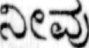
ನೀವು
